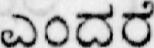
ಎಂದರೆ
